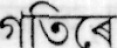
গতিৰে
